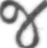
જ
